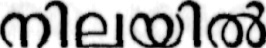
നിലയില്‍
